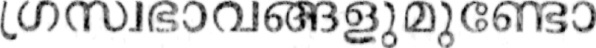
ഗ്രസ്വഭാവങ്ങളുമുണ്ടോ
